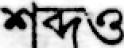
শব্দও
